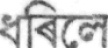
ধৰিলে
